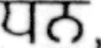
ਧਨ,
